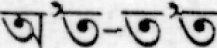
অ'ত-ত'ত
